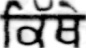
ਕਿੱਥੇ
